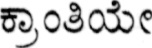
ಕ್ರಾಂತಿಯೇ
